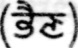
(ਭੈਣ)
